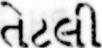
તેટલી
